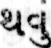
થવું
